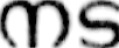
നട
